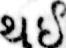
થઈ
